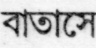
বাতাসে
